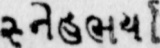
સ્નેહભર્યા
